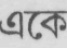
একে
